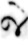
જે
